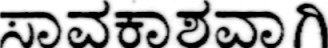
ಸಾವಕಾಶವಾಗಿ
